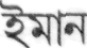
ইমান
